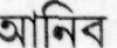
আনিব
